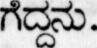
ಗೆದ್ದನು.
